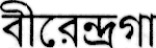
বীরেন্দ্রগা
